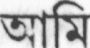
আমি
